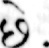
છે.
